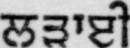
ਲੜਾਈ
